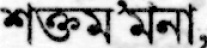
শক্তম’মনা,
